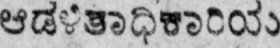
ಆಡಳಿತಾಧಿಕಾರಿಯ
